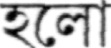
হলো
